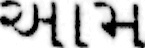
આમ
